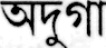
অদুগা
